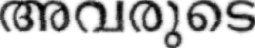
അവരുടെ
